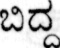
ಬಿದ್ದ
